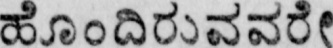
ಹೊಂದಿರುವವರೇ
